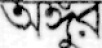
অঙ্গুর
